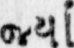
જ્યાં
